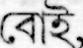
বোই,
